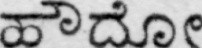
ಹೌದೋ
